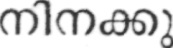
നിനക്കു
